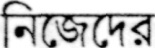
নিজেদের
